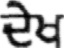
ਦੇਖ
